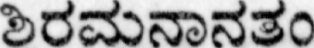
ಶಿರಮನಾನತಂ
